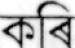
কৰি
